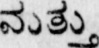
ಮತ್ತು
